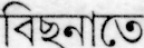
বিছনাতে
